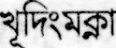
খূদিংমক্না
